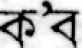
ক'ব
